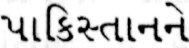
પાકિસ્તાનને
